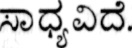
ಸಾಧ್ಯವಿದೆ.
